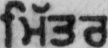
ਮਿੱਤਰ
